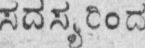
ಸದಸ್ಯರಿಂದ
